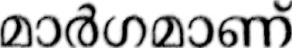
മാര്‍ഗമാണ്
